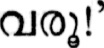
വരൂ!'
